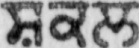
ਸ਼ਕਲ
